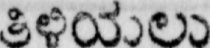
ತಿಳಿಯಲು
